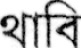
থাবি
